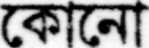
কোনো
